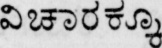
ವಿಚಾರಕ್ಕೂ
